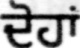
ਦੋਹਾਂ
